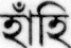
হাঁহি
